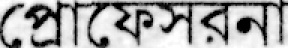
প্রোফেসরনা
